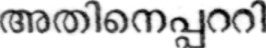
അതിനെപ്പററി
